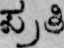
ಪ್ರತಿ
